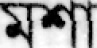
মশা
